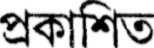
প্রকাশিত
